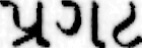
પ્રગટ
